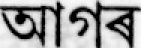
আগৰ
